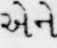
એને
